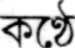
কণ্ঠে
